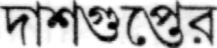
দাশগুপ্তের
